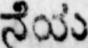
ನೆಯ
